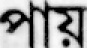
পায়
